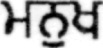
ਮਨੁਖ
